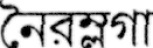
নৈরম্লগা
